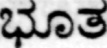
ಭೂತ
